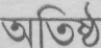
অতিষ্ঠ
